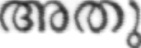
അതു
